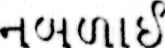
નબળાઈ
